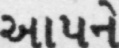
આપને
